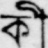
কী
